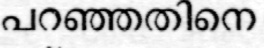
പറഞ്ഞതിനെ
